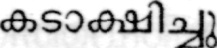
കടാക്ഷിച്ചു
